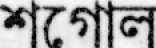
শগোল
